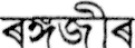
ৰঙ্গজীৰ
